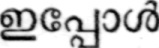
ഇപ്പോള്‍
